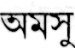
অমসু
